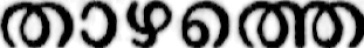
താഴത്തെ
